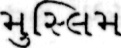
મુસ્લિમ
